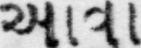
આવા
